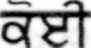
ਕੋਈ
